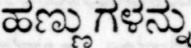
ಹಣ್ಣುಗಳನ್ನು
